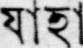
যাহা
